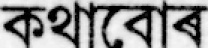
কথাবোৰ
